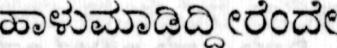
ಹಾಳುಮಾಡಿದ್ದೀರೆಂದೇ
